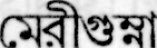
মেরীগুম্না
